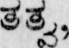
ತತ್ವ,
